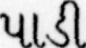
પાડી
